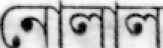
নোলাল
